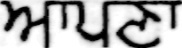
ਆਪਣਾ
